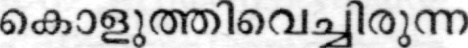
കൊളുത്തിവെച്ചിരുന്ന
